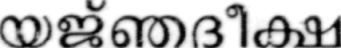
യജ്ഞദീക്ഷ
